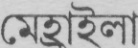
মেহ্ৰাইলা
